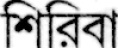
শিরিবা
